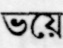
ভয়ে
